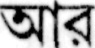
আর
